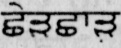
ਛੇੜਛਾੜ
